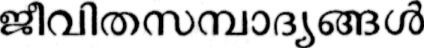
ജീവിതസമ്പാദ്യങ്ങള്‍
